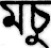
মচু
